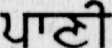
ਪਾਣੀ
